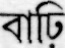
বাঢ়ি
